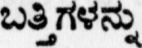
ಬತ್ತಿಗಳನ್ನು
